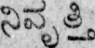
ನಿವೃತ್ತಿ
